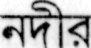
নদীর
